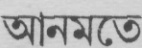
আনমতে
